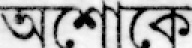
অশোকে
